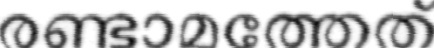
രണ്ടാമത്തേത്
